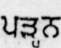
ਪੜ੍ਹਨ
